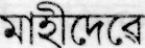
মাহীদেৱে
